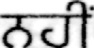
ਨਹੀਂ
